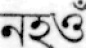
নহওঁ
